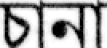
চানা
